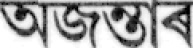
অজন্তাৰ
